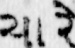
ચારે
